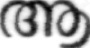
ആ
